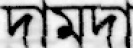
দামদা
